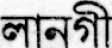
লানগী
